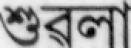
শুৱলা
